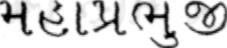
મહાપ્રભુજી
